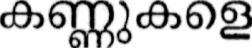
കണ്ണുകളെ
